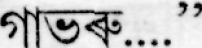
গাভৰু...."
